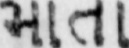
માતા
